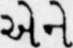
એને
